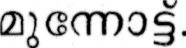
മുന്നോട്ട്.
